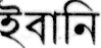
ইবানি
